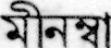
মীনম্বা
